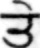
ਤੇ
